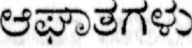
ಆಘಾತಗಳು
